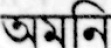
অমনি
